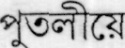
পুতলীয়ে
